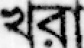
খরা
